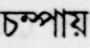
চম্পায়
